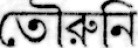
তৌরুনি
